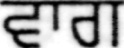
ਵਾਗ
